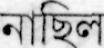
নাছিল
